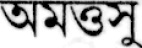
অমত্তসু
